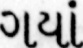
ગયાં
